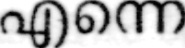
എന്നെ
